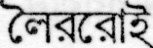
লৈররোই
